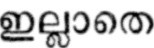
ഇല്ലാതെ
